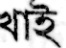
খাই
